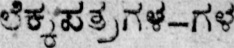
ಲೆಕ್ಕಪತ್ರಗಳ-ಗಳ
